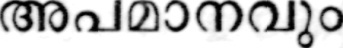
അപമാനവും
